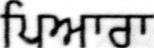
ਪਿਆਰਾ
